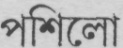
পশিলো
